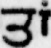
ਤਾਂ
